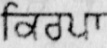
ਕਿਰਪਾ
